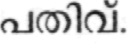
പതിവ്.
